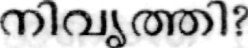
നിവൃത്തി?
